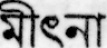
মীৎনা
